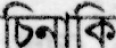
চিনাকি
